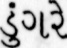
ડુંગરે
